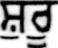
ਸ਼ੁਰੂ
